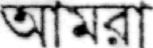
আমরা
